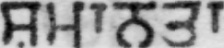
ਸ਼ਮਾਨਤਾ
